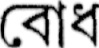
বোধ
